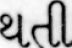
થતી
